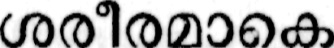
ശരീരമാകെ
